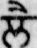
ਲੈ
